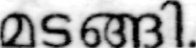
മടങ്ങി.
